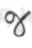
જ
